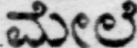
ಮೇಲೆ
